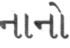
નાનો
